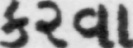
કરવા
